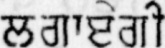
ਲਗਾਏਗੀ
